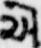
એ
